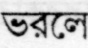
ভরলে
